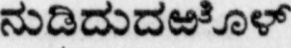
ನುಡಿದುದಱೊಳ್
